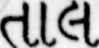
તાલ
